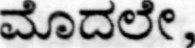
ಮೊದಲೇ,
